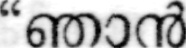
“ഞാന്‍
